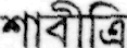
শাবীত্রি
